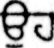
ਉਹ
